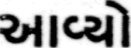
આવ્યો
